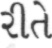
રીતે
